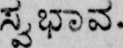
ಸ್ವಭಾವ.
